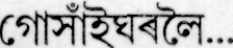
গোসাঁইঘৰলৈ...
